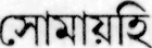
সোমায়হি
